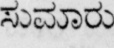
ಸುಮಾರು
